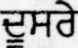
ਦੂਸਰੇ
